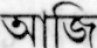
আজি
